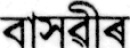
বাসৱীৰ
